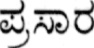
ಪ್ರಸಾರ
